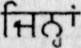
ਜਿਨ੍ਹਾਂ
